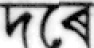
দৰে
